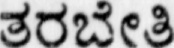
ತರಬೇತಿ
